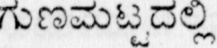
ಗುಣಮಟ್ಟದಲ್ಲಿ
